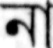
না
